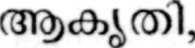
ആകൃതി,
